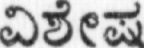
ವಿಶೇಷ
